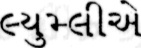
લ્યુમ્લીએ
